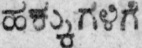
ಹಕ್ಕುಗಳಿಗೆ
